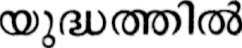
യുദ്ധത്തില്‍
